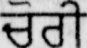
ਚੋਰੀ
